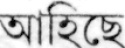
আহিছে
